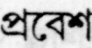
প্রবেশ
